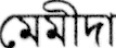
মেমীদা
